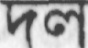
দল
